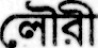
লৌরী
